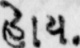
હોય.
